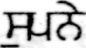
ਸੁਪਨੇ
